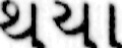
થયા
